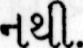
નથી.
